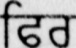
ਫਿਰ
